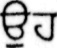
ਉਹ
